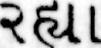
રહ્યા
